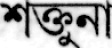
শক্তুনা
